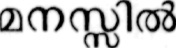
മനസ്സില്‍
